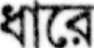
ধারে
